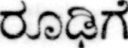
ರೂಢಿಗೆ
